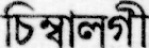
চিম্বালগী
